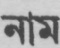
নাম
